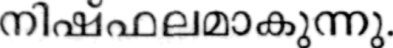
നിഷ്ഫലമാകുന്നു.
